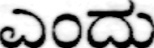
ಎಂದು
